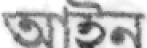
আইন
